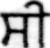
ਸੀ
